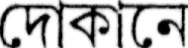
দোকানে
